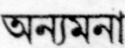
অন্যমনা
